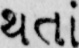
થતાં
